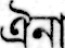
ঐনা
